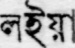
লইয়া
